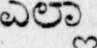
ಎಲ್ಲಾ
